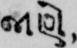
જાણે,
